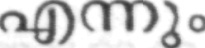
എന്നും
